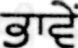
ਭਾਵੇਂ
